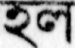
হল
